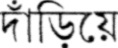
দাঁড়িয়ে
